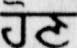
ਹੋਣ
